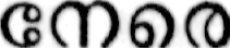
നേരെ
